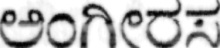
ಅಂಗೀರಸ
